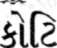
કોટિ
